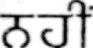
ਨਹੀਂ
